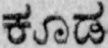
ಕೂಡ
